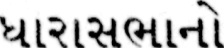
ધારાસભાનો
